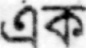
এক
